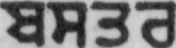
ਬਸਤਰ
